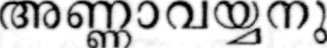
അണ്ണാവയ്യനു
